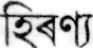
হিৰণ্য
